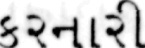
કરનારી
